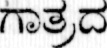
ಗಾತ್ರದ
